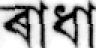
ৰাধা
